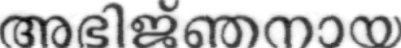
അഭിജ്ഞനായ
